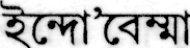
ইন্দো’বেম্মা
